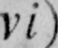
vi)
